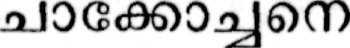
ചാക്കോച്ചനെ
